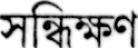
সন্ধিক্ষণ
